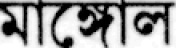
মাঙ্গোল
